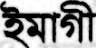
ইমাগী
